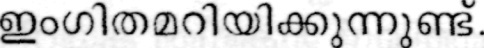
ഇംഗിതമറിയിക്കുന്നുണ്ട്.
